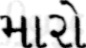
મારો
